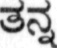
ತನ್ನ
